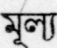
মূল্য
